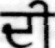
ਦੀ
